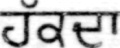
ਹੱਕਦਾ
